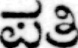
ಪತಿ
